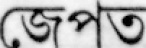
জেপত
